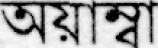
অয়াম্বা
